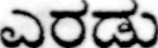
ಎರಡು
